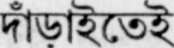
দাঁড়াইতেই
